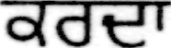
ਕਰਦਾ
